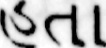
હતા
